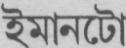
ইমানটো
